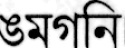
ঙমগনি
